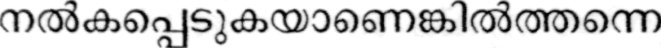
നല്‍കപ്പെടുകയാണെങ്കില്‍ത്തന്നെ
